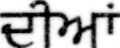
ਦੀਆਂ
